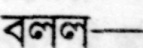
বলল–
